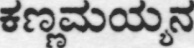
ಕಣ್ಣಮಯ್ಯನ
